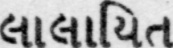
લાલાયિત
